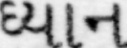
ધ્યાન
